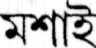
মশাই
